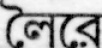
লৈরে
